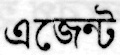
PMSD)
